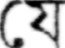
যে
